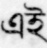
এই
